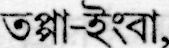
তপ্পা-ইংবা,
